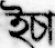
ইচা
